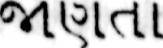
જાણતા
